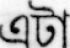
এটা
